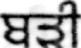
ਬੜੀ
